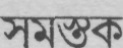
সমস্তক
